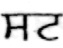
ਸਟ
